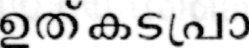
ഉത്കടപ്രാ
